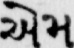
એમ
